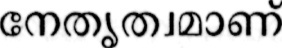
നേതൃത്വമാണ്
